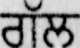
ਗੱਲ
